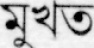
মুখত
